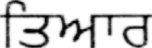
ਤਿਆਰ
